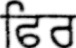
ਫਿਰ
